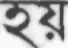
হয়
